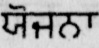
ਯੋਜਨਾ
